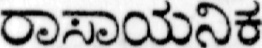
ರಾಸಾಯನಿಕ
